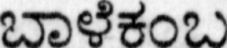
ಬಾಳೆಕಂಬ
